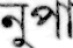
নুপা
